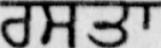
ਰਸਤਾ
